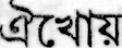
ঐখোয়
